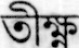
তীক্ষ্ণ
